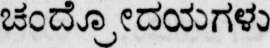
ಚಂದ್ರೋದಯಗಳು
